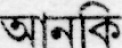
আনকি
